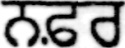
ਨਫ਼ਰ
